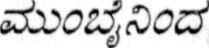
ಮುಂಬೈನಿಂದ
